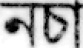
নচা
